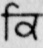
ਕਿ
